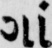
ગાં
